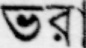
ভরা
